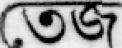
তেজ
